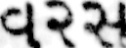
વરસ
